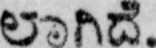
ಲಾಗಿದೆ.
